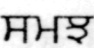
ਸਮਝ
